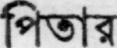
পিতার
